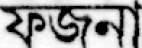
ফজনা
